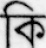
কি
